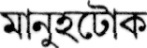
মানুহটোক
